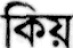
কিয়
